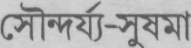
সৌন্দৰ্য্য-সুষমা
